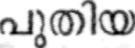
പുതിയ
